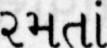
રમતાં
